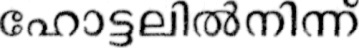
ഹോട്ടലില്‍നിന്ന്
